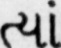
ત્યાં
